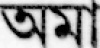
অমা
